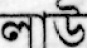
লাউ
